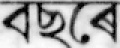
বছৰে
